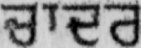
ਚਾਦਰ
